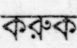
করুক
